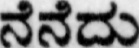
ನೆನೆದು
